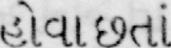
હોવાછતાં
